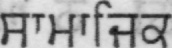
ਸਾਮਾਜਿਕ
